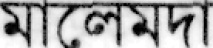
মালেমদা
